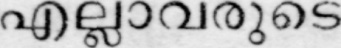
എല്ലാവരുടെ
